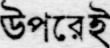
উপরেই
